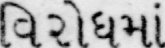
વિરોધમાં
